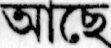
আছে
